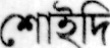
শোইদি
